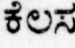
ಕೆಲಸ
